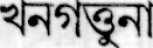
খনগত্তুনা
